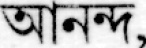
আনন্দ,
